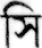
সি
